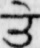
ਤੇ
